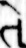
તે
